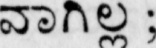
ವಾಗಿಲ್ಲ;
